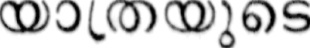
യാത്രയുടെ
